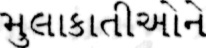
મુલાકાતીઓને
